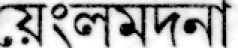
য়েংলমদনা
